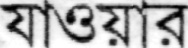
যাওয়ার
